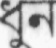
ধুন
